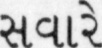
સવારે
